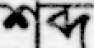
শব্দ
